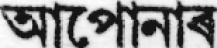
আপোনাৰ
